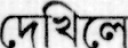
দেখিলে
